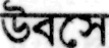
উবসে
